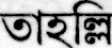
তাহল্লি
